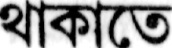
থাকাতে
